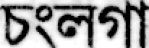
চংলগা
